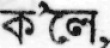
ক'লে,
